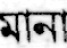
মানা
